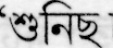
'শুনিছ
